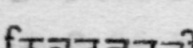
ਨਿਕਟਵਰਤੀ
